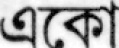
একো
